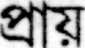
প্রায়
